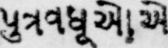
પુત્રવધૂઓએ
